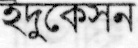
ইদুকেসন
